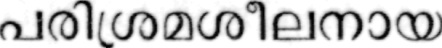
പരിശ്രമശീലനായ
